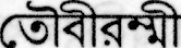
তৌবীরম্মী
